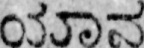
ಯಾವ
